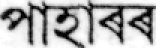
পাহাৰৰ
